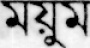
ময়ুম
